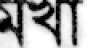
মখা
